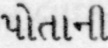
પોતાની
